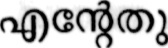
എന്റേതു
